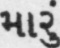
મારું
